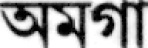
অমগা
